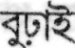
বুঢ়াই
